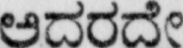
ಅದರದೇ
